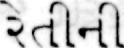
રેતીની
